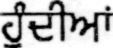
ਹੁੰਦੀਆਂ
